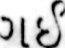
ગઈ
